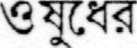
ওষুধের
